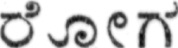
ರೋಗ
